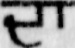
ਦਾ
